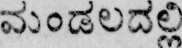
ಮಂಡಲದಲ್ಲಿ
